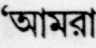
‘আমরা
